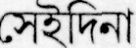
সেইদিনা
